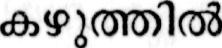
കഴുത്തില്‍
